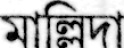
মাল্লিদা
